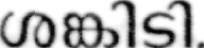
ശങ്കിടി.
